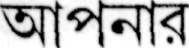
আপনার
